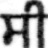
ਸੀ
